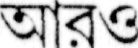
আরও
